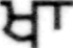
ਖਾ
